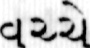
વચ્ચે
